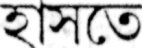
হাসতে
